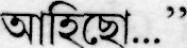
আহিছো..."
